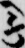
કે
